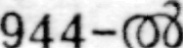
944-ല്‍
